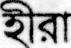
হীরা
